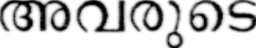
അവരുടെ
